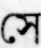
সে
